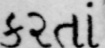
કરતાં
